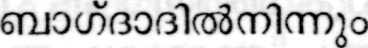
ബാഗ്ദാദില്‍നിന്നും
